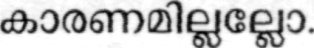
കാരണമില്ലല്ലോ.
